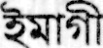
ইমাগী
